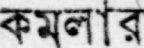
কমলার
